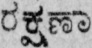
ರಕ್ಷಣಾ
